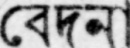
বেদনা
